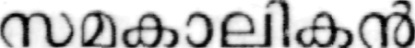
സമകാലികന്‍
